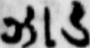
ઝાડ
